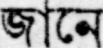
জানে
